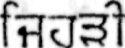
ਜਿਹੜੀ
